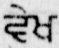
ਵੇਖ
